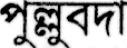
পুল্লুবদা
